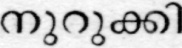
നുറുക്കി
